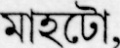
মাহটো,
